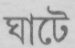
ঘাটে
